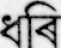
ধৰি
